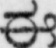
ಈ
